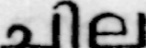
ചില
